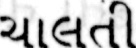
ચાલતી
